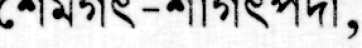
শেমগৎ-শাগৎপদা,
